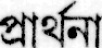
প্রার্থনা
